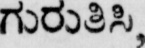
ಗುರುತಿಸಿ,
